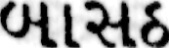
બાસઠ
